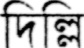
দিল্লি
